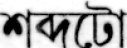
শব্দটো
